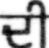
ਦੀ
